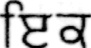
ਇਕ
